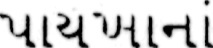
પાયખાનાં
